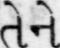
તેને
